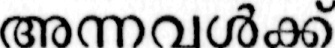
അന്നവള്‍ക്ക്
